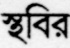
স্থবির
